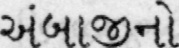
અંબાજીનો
